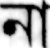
না
